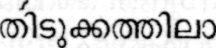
തിടുക്കത്തിലാ
